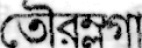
তৌরম্লগা
